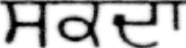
ਸਕਦਾ
